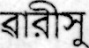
ৱারীসু
